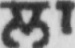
ਲਾ
